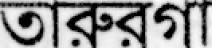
তারুরগা
